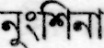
নুংশিনা
